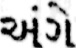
અંગે
